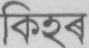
কিহৰ
